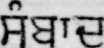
ਸੰਬਾਦ
